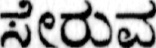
ಸೇರುವ
